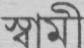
স্বামী
